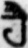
ਹੈ
